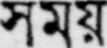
সময়
